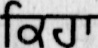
ਕਿਹਾ
